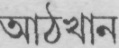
আঠখান
